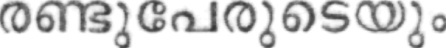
രണ്ടുപേരുടെയും
